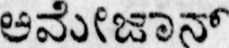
ಅಮೇಜಾನ್
